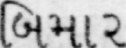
બિમાર
